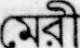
মেরী
